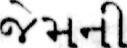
જેમની
